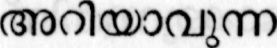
അറിയാവുന്ന
